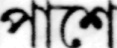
পাশে
